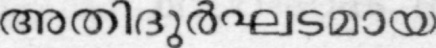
അതിദുര്‍ഘടമായ
